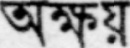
অক্ষয়
